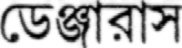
ডেঞ্জারাস
